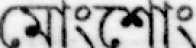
মোংশোং
